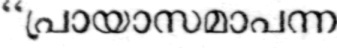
“പ്രായാസമാപന്ന
